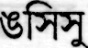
ঙসিসু
